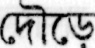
দৌড়ে
